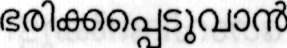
ഭരിക്കപ്പെടുവാന്‍
